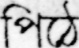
পিঠে
